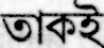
তাকই
